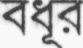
বধূর
